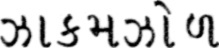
ઝાકમઝોળ
